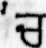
'ਚ
